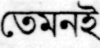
তেমনই
